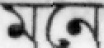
মনে
